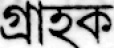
গ্ৰাহক
